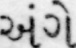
અંગે
